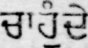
ਚਾਹੁੰਦੇ
